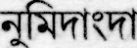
নুমিদাংদা
